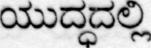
ಯುದ್ಧದಲ್ಲಿ
